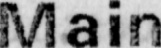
Main
